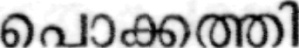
പൊക്കത്തി
